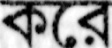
করে
